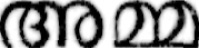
അമ്മ
